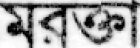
মরক্তা
